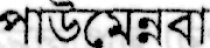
পাউমেন্নবা
